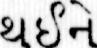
થઈને
